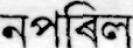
নপৰিল
